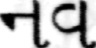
નવ
